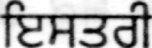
ਇਸਤਰੀ
